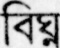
বিঘ্ন
